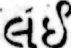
લઈ
